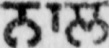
ਨਾਲ
